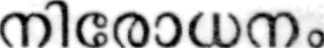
നിരോധനം
